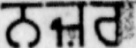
ਨਜ਼ਰ
